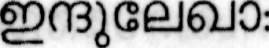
ഇന്ദുലേഖാ:
